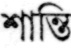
শান্তি
